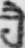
ਹੈ
